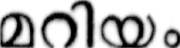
മറിയം
